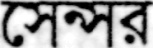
সেন্সর
